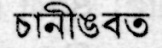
চানীঙবত
